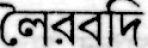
লৈরবদি
